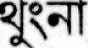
থুংনা
